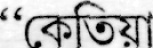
"কেতিয়া
